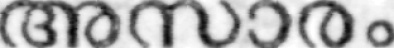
അസാരം
